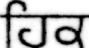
ਹਿਕ
